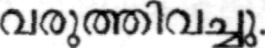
വരുത്തിവച്ചു.
